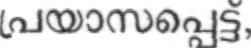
പ്രയാസപ്പെട്ട്,
